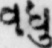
વધું
